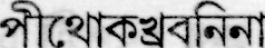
পীথোকখ্রবনিনা
